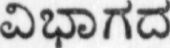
ವಿಭಾಗದ
